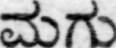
ಮಗು
